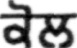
ਕੋਲ
